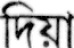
দিয়া
